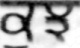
ਕੁਝ
